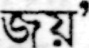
জয়’
